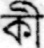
কী
